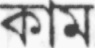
কাম
